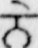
ਨੇ
